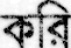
করি
